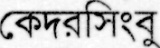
কেদরসিংবু
